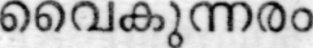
വൈകുന്നരം
